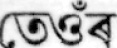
তেওঁৰ
